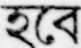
হবে
